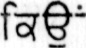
ਕਿਉਂ
